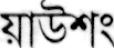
য়াউশং
